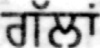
ਗੱਲਾਂ
